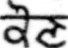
ਕੌਣ
